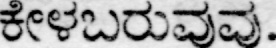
ಕೇಳಬರುವುವು.
